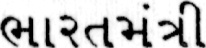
ભારતમંત્રી
